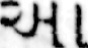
આ
